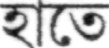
হাতে
